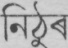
নিঠুৰ
